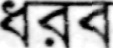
ধরব
